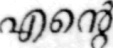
എന്റെ
